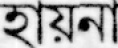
হায়না
